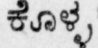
ಕೊಳ್ಳ
